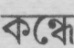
কন্ধে
